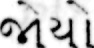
જોયો
